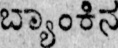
ಬ್ಯಾಂಕಿನ
